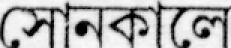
সোনকালে
